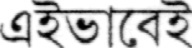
এইভাবেই
